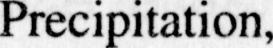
Precipitation,
